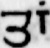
ਤਾਂ
